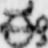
ಈ
